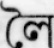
লৈ
